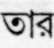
তার
